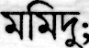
মমিদু;
